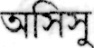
অসিসু
